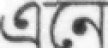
এনে
